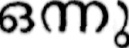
ഒന്നു
